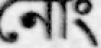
নোং
